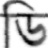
ডি
